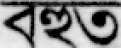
বহুত
